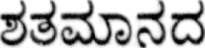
ಶತಮಾನದ
